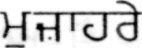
ਮੁਜ਼ਾਹਰੇ
